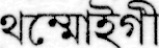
থম্মোইগী
